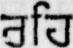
ਰਹਿ
